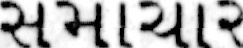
સમાચાર
